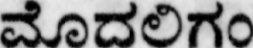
ಮೊದಲಿಗಂ
